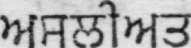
ਅਸਲੀਅਤ
